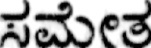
ಸಮೇತ
